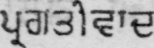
ਪ੍ਰਗਤੀਵਾਦ
